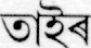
তাইৰ
